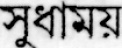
সুধাময়
